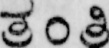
ತಂತಿ
